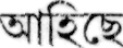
আহিছে
